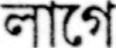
লাগে
